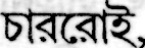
চাররোই,
